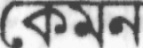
কেমন
